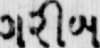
ગરીબ
